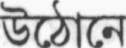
উঠোনে
